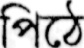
পিঠে
